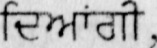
ਦਿਆਂਗੀ,
